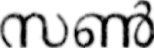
സണ്‍
